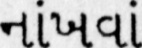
નાંખવાં
